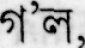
গ'ল,
